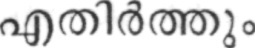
എതിര്‍ത്തും
